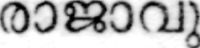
രാജാവു
